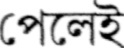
পেলেই
